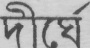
দীৰ্ঘে
